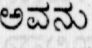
ಅವನು
